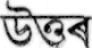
উত্তৰ
